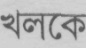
খলকে
